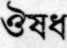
ঔষধ
